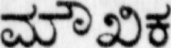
ಮೌಖಿಕ
